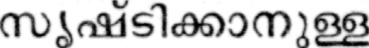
സൃഷ്ടിക്കാനുള്ള
